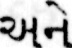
અને
